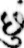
છું
